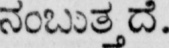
ನಂಬುತ್ತದೆ.
